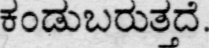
ಕಂಡುಬರುತ್ತದೆ.
